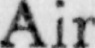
Air
